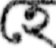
হে
